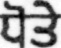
ਧੋਤੇ
